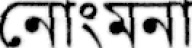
নোংমনা
